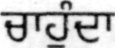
ਚਾਹੁੰਦਾ
